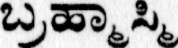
ಬ್ರಹ್ಮಾಸ್ಮಿ
